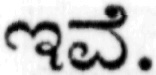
ಇವೆ.
